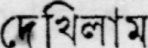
দেখিলাম
